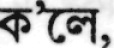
ক'লে,
